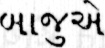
બાજુએ
